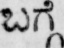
ಬಗ್ಗೆ
